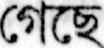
গেছে
